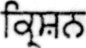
ਕ੍ਰਿਸ਼ਨ
